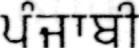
ਪੰਜਾਬੀ
